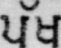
ਪੱਖ
